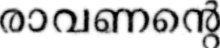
രാവണന്റെ
